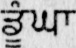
ਡੂੰਘਾ
